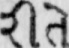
રીતે
